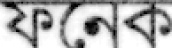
ফনেক
